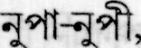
নুপা-নুপী,
